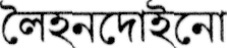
লৈহনদোইনো
